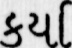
કર્યા
